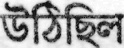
উঠিছিল
